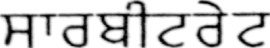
ਸਾਰਬੀਟਰੇਟ
